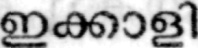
ഇക്കാളി
